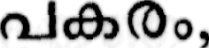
പകരം,
